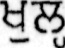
ਖੁਲ੍ਹ
